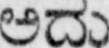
ಅದು
